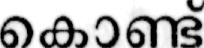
കൊണ്ട്
